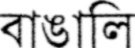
বাঙালি
